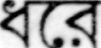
ধরে
